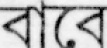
বাবে
